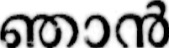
ഞാന്‍
